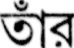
তাঁর
